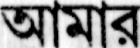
আমার
